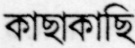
কাছাকাছি
